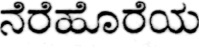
ನೆರೆಹೊರೆಯ
